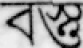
বস্তু
